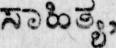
ಸಾಹಿತ್ಯ,
